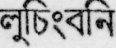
লুচিংবনি
